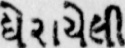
ઘેરાયેલી
